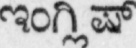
ಇಂಗ್ಲಿಷ್
